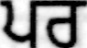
ਪਰ
